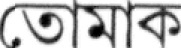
তোমাক
